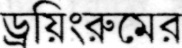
ড্রয়িংরুমের
